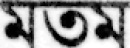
মতম
